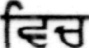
ਵਿਚ
